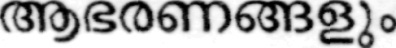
ആഭരണങ്ങളും
